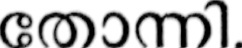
തോന്നി.
